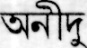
অনীদু
